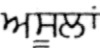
ਅਸੂਲਾਂ
